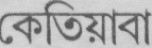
কেতিয়াবা
